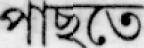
পাছতে
